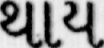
થાય
